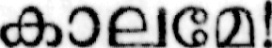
കാലമേ!
